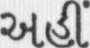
અહીં
